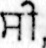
ਸੀ,
